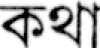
কথা
